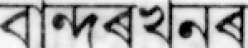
বান্দৰখনৰ
